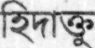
হিদাক্তু
